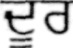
ਦੂਰ
